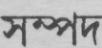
সম্পদ
